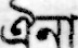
ঐনা
